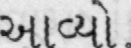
આવ્યો.
